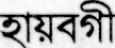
হায়বগী
